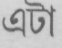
এটা
